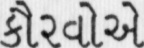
કૌરવોએ
